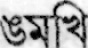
ঙমখি
